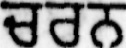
ਚਰਨ
